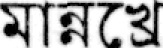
মান্নখ্রে
